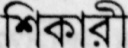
শিকারী
